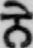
ਨੇ
